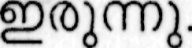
ഇരുന്നു.
